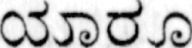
ಯಾರೂ
